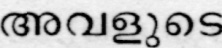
അവളുടെ
